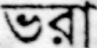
ভরা
